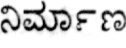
ನಿರ್ಮಾಣ
